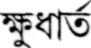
ক্ষুধার্ত
